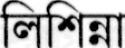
লিশিন্না
